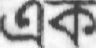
এক
